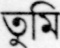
তুমি
